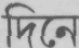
দিনে
